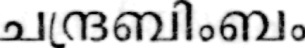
ചന്ദ്രബിംബം
